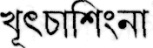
খূৎচাশিংনা
